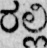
ರಲ್ಲಿ
